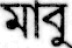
মাবু
